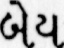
બેય
